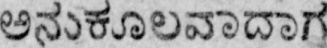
ಅನುಕೂಲವಾದಾಗ
